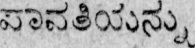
ಪಾವತಿಯನ್ನು
